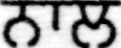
ਨਾਲ
